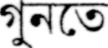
গুনতে
